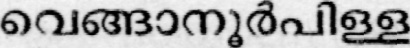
വെങ്ങാനൂര്‍പിള്ള
